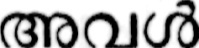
അവള്‍
